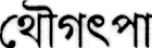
থৌগৎপা
